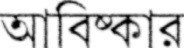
আবিষ্কার
